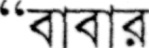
“বাবার
